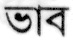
ভাব
